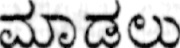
ಮಾಡಲು
